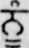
ਨੂੰ
